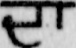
ਦਾ
